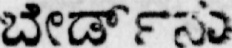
ಬೇರ್ಡ್‌ನು
